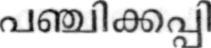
പഞ്ചിക്കപ്പി
